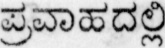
ಪ್ರವಾಹದಲ್ಲಿ
